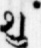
શું
